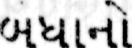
બધાનો
